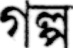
গল্প
